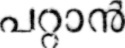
പറ്റാന്‍
